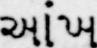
આંખ
